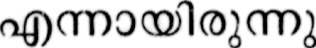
എന്നായിരുന്നു
